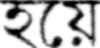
হয়ে
